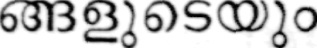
ങ്ങളുടെയും
